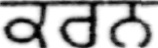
ਕਰਨ
